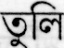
তুলি
